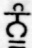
ਨੂੰ
